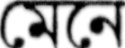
মেনে
